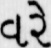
વરે
